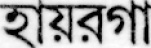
হায়রগা
